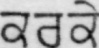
ਕਰਕੇ
